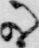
જે
